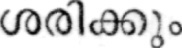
ശരിക്കും
